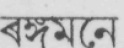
ৰঙ্গমনে
